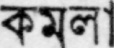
কমলা
